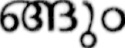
ങ്ങും
